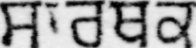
ਸਾਰਥਕ
